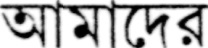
আমাদের
